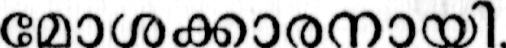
മോശക്കാരനായി.
